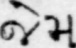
જેમ
